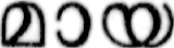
മായ
